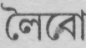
লৈবো
